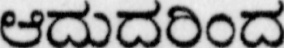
ಆದುದರಿಂದ
